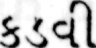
કડવી
